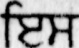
ਇਸ
